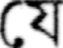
যে
